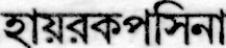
হায়রকপসিনা
